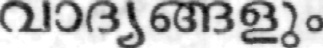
വാദ്യങ്ങളും
